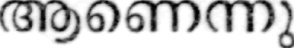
ആണെന്നു
